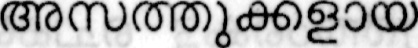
അസത്തുക്കളായ
